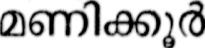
മണിക്കൂര്‍
